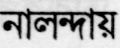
নালন্দায়
